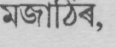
মজাঠিৰ,
